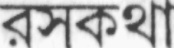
রসকথা
